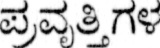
ಪ್ರವೃತ್ತಿಗಳ
